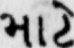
માટે
